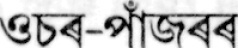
ওচৰ-পাঁজৰৰ
